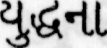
યુદ્ધના
